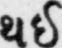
થઈ
